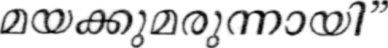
മയക്കുമരുന്നായി”
